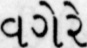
વગેરે
